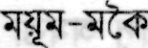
ময়ূম-মকৈ
